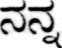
ನನ್ನ
